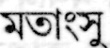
মতাংসু
